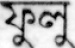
ফুলু
